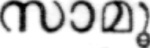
സാമൂ
